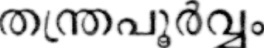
തന്ത്രപൂര്‍വ്വം
